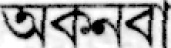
অকনবা
